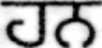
ਹਨ
